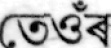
তেওঁৰ
